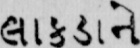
લાકડાને
